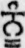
ਨੂੰ
